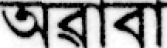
অৱাবা
